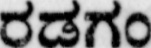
ರಡಗಂ
